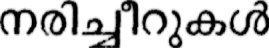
നരിച്ചീറുകള്‍
